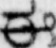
ಈ
